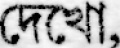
দেখো,
